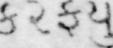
કરફયુ
